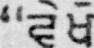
''ਵੇਖੋ
